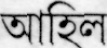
আহিল
